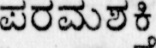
ಪರಮಶಕ್ತಿ
